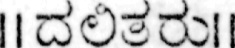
||ದಲಿತರು||
